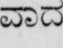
ವಾದ
